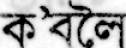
ক'বলৈ
